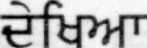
ਦੇਖਿਆ
